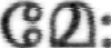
മേ:
